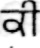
ਕੀ
